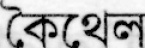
কৈথেল
